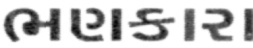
ભણકારા
